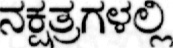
ನಕ್ಷತ್ರಗಳಲ್ಲಿ
